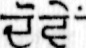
ਦੋਵੇਂ
